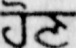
ਹੋਣ
